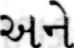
અને
